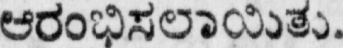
ಆರಂಭಿಸಲಾಯಿತು.
